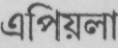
এপিয়লা
